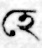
হে
